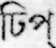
ঢিপ্
